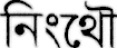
নিংথৌ
